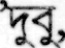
’দুবু,
